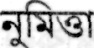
নুমিত্তা
